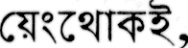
য়েংথোকই,
